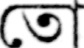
তো
